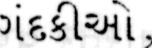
ગંદકીઓ,
